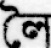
লৈ
